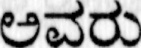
ಅವರು
